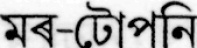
মৰ-টোপনি
